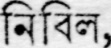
নিবিল,
